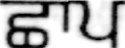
ਛਾਪ
